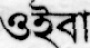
ওইবা
